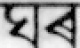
ঘৰ
